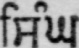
ਸਿੰਘ
